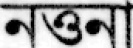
নত্তনা
